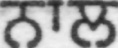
ਨਾਲ
